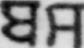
ਬਸ
